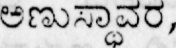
ಅಣುಸ್ಥಾವರ,
